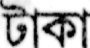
টাকা
